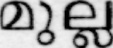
മുല്ല
